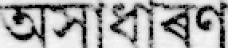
অসাধাৰণ
